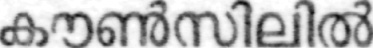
കൌണ്‍സിലില്‍
